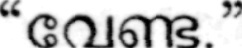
“വേണ്ട."
